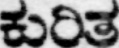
ಕುರಿತ
